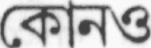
কোনও
